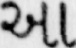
આ
